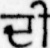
ਦੀ
